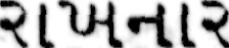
રાખનાર
